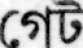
গেট
